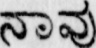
ನಾವು
